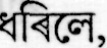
ধৰিলে,
